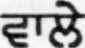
ਵਾਲੇ
